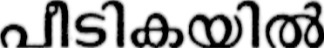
പീടികയില്‍
